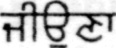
ਜੀਉਣਾ
